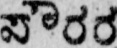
ಪೌರರ
